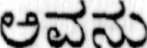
ಅವನು
